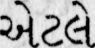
એટલે
